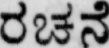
ರಚನೆ
